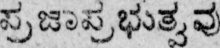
ಪ್ರಜಾಪ್ರಭುತ್ವವು
